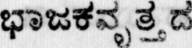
ಭಾಜಕವೃತ್ತದ
